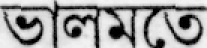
ভালমতে
